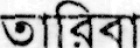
তারিবা
